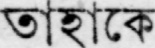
তাহাকে
